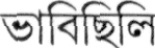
ভাবিছিলি
